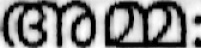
അമ്മ:
